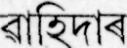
ৱাহিদাৰ
